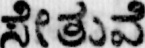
ಸೇತುವೆ
